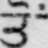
ਤੋਂ
